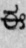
ಈ
